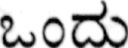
ಒಂದು
